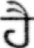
ਹੈ
